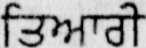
ਤਿਆਰੀ
